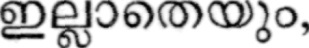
ഇല്ലാതെയും,
